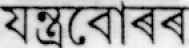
যন্ত্রবোৰৰ
